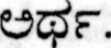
ಅರ್ಥ.
